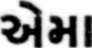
એમા
